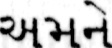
અમને
